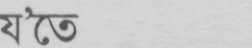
য'তে
